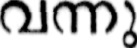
വന്നു
